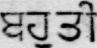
ਬਹੁਤੀ
